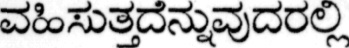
ವಹಿಸುತ್ತದೆನ್ನುವುದರಲ್ಲಿ
